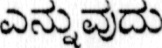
ಎನ್ನುವುದು
